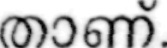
താണ്.
